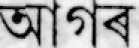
আগৰ
